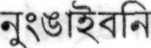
নুংঙাইবনি
